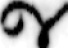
જ
